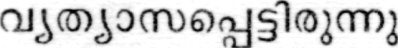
വ്യത്യാസപ്പെട്ടിരുന്നു
